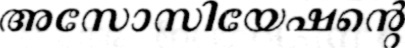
അസോസിയേഷന്റെ
